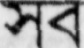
সব
